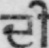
ਦੀ
